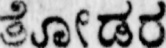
ತೋಡರ
